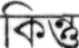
কিন্তু
